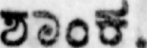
ಶಾಂಕ,
